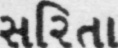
સરિતા
